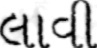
લાવી
